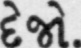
દેજો.
